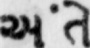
અંતે
